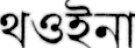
থওইনা
